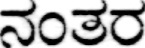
ನಂತರ
